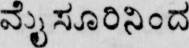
ಮೈಸೂರಿನಿಂದ
